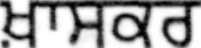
ਖ਼ਾਸਕਰ
